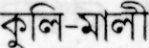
কুলি-মালী
